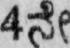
4ನೇ
